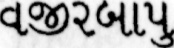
વજીરબાપુ
